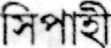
সিপাহী
